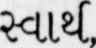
સ્વાર્થ,
